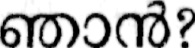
ഞാന്‍?
